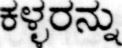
ಕಳ್ಳರನ್ನು
